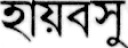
হায়বসু
